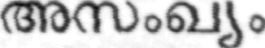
അസംഖ്യം
